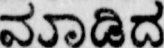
ಮಾಡಿದ
